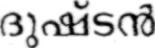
ദുഷ്ടന്‍
